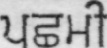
ਪਛਮੀ
